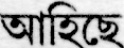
আহিছে
